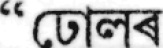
"ঢোলৰ
